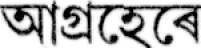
আগ্রহেৰে
